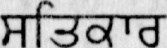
ਸਤਿਕਾਰ
